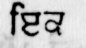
ਇਕ
